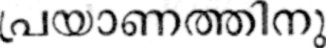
പ്രയാണത്തിനു
